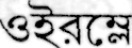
থৌরিবীদু
